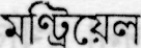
মণ্ট্রিয়েল
